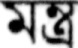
মন্ত্র
